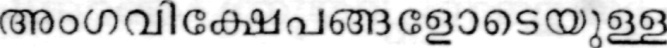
അംഗവിക്ഷേപങ്ങളോടെയുള്ള
